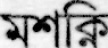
মশক্নি
